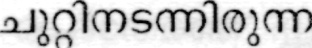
ചുറ്റിനടന്നിരുന്ന
